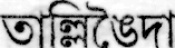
তাল্লিঙৈদা
